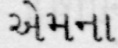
એમના
